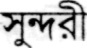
সুন্দরী
